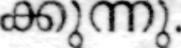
ക്കുന്നു.
